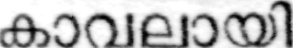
കാവലായി
